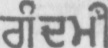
ਗੰਦਮੀ
